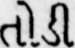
તોડી
